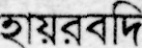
হায়রবদি
